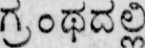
ಗ್ರಂಥದಲ್ಲಿ
